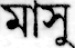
মাসু
